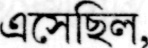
এসেছিল,
